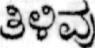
ತಿಳಿವು
